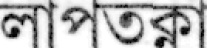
লাপতক্না
